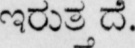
ಇರುತ್ತದೆ.
